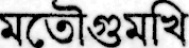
মতৌগুমখি
